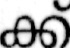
ക്ക്
